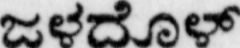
ಜಳದೊಳ್
